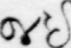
જઈ
